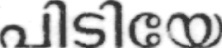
പിടിയേ
